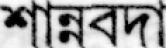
শান্নবদা
